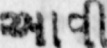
આવી
